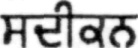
ਸਦੀਕਨ
